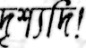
দৃশ্যদি!
